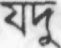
যদু
